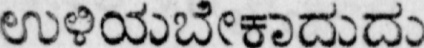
ಉಳಿಯಬೇಕಾದುದು
